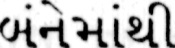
બંનેમાંથી
